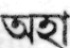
অহা
